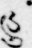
હું
